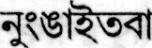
নুংঙাইতবা
